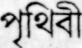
পৃথিবী
